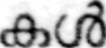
കള്‍
